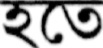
হতে
